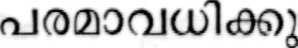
പരമാവധിക്കു
